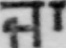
ਜਾ
